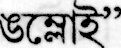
ঙম্লোই”
